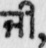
ਜੀ,
